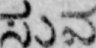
ಸುವ
